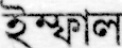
ইম্ফাল
